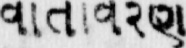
વાતાવરણ
